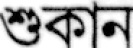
শুকান
